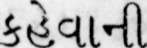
કહેવાની
